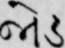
જોડ
